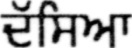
ਦੱਸਿਆ
